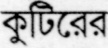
কুটিরের
